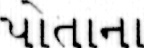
પોતાના
